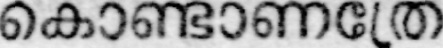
കൊണ്ടാണത്രേ
